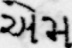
એમ
